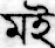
মই
